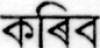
কৰিব
